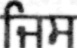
ਜਿਸ
